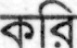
করি
